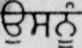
ਉਸਨੂੰ
